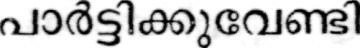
പാര്‍ട്ടിക്കുവേണ്ടി
